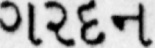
ગરદન
